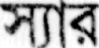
স্যার
